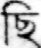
ছি
